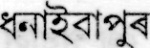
ধনাইবাপুৰ
